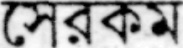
সেরকম
